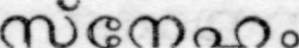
സ്നേഹം
